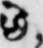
છે,
